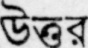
উত্তর
